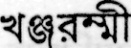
খঞ্জরম্মী
